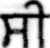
ਸੀ
